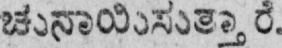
ಚುನಾಯಿಸುತ್ತಾರೆ.
